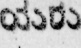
ಯರು
